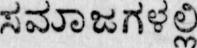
ಸಮಾಜಗಳಲ್ಲಿ
